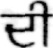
ਦੀ
